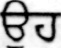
ਉਹ
